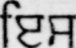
ਇਸ
